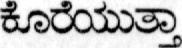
ಕೊರೆಯುತ್ತಾ
